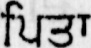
ਪਿਤਾ
